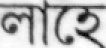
লাহে
